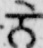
ਨੇ
